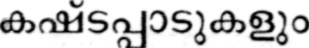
കഷ്ടപ്പാടുകളും
